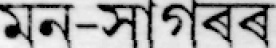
মন-সাগৰৰ
